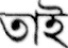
তাই
